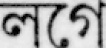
লগে
